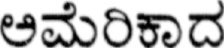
ಅಮೆರಿಕಾದ
